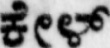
ಕೇಳ್
